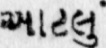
આટલું
